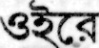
ওইরে
